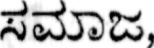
ಸಮಾಜ,
